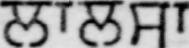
ਲਾਲਸਾ
